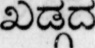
ಖಡ್ಗದ
